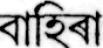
বাহিৰা
